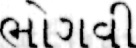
ભોગવી
